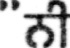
''ਨੀ
